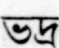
ভদ্র
